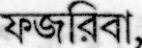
ফজরিবা,
